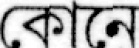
কোনে
